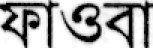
ফাওবা
